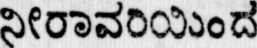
ನೀರಾವರಿಯಿಂದ
